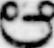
ಆ
